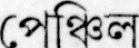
পেঞ্চিল
